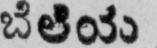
ಬೆಲೆಯ
